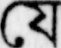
যে
